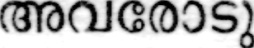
അവരോടു
